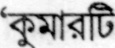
‘কুমারটি
